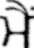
ਮੈਂ
